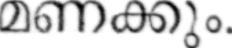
മണക്കും.
